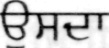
ਉਸਦਾ
